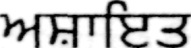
ਅਸ਼ਾਇਤ
